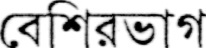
বেশিরভাগ
